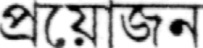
প্রয়োজন
